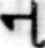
ન
